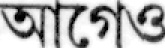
আগেও
